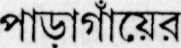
পাড়াগাঁয়ের
